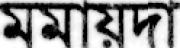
মমায়দা
